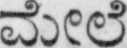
ಮೇಲೆ
